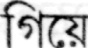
গিয়ে
